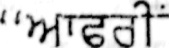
''ਆਫਰੀਂ
